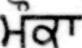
ਮੌਕਾ
